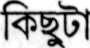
কিছুটা
